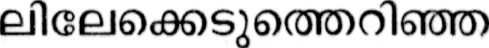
ലിലേക്കെടുത്തെറിഞ്ഞ
